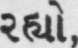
રહ્યો,
